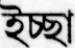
ইচ্ছা
